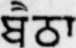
ਬੈਠਾ
